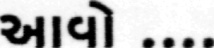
આવો.......
